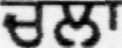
ਚਲਾ
